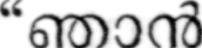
“ഞാന്‍
